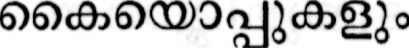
കൈയൊപ്പുകളും
